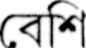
বেশি
